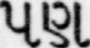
પણ
